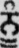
ਨੂੰ
